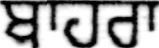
ਬਾਹਰਾ
